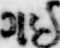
ગઈ
